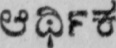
ಆರ್ಥಿಕ
